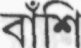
বাঁশি
